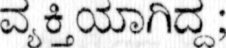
ವ್ಯಕ್ತಿಯಾಗಿದ್ದ;
